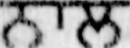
ਨਾਲ
